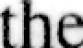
the
